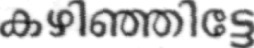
കഴിഞ്ഞിട്ടേ
